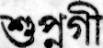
শুপ্নগী
